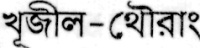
খূজীল-থৌরাং
